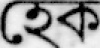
হেক
